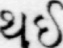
થઈ
